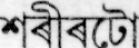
শৰীৰটো
